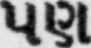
પણ
